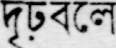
দৃঢ়বলে
